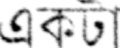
একটা
